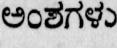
ಅಂಶಗಳು
